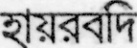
হায়রবদি
